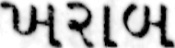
ખરાબ
